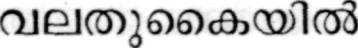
വലതുകൈയില്‍
